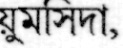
য়ুমসিদা,
